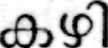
കഴി
